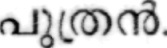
പുത്രന്‍.
